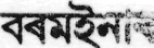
বৰমইনাৰ
